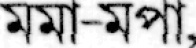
মমা-মপা,
